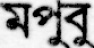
মপুবু
